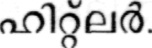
ഹിറ്റ്ലര്‍.
